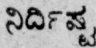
ನಿರ್ದಿಷ್ಟ
